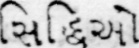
સિદ્ધિઓ
